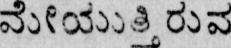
ಮೇಯುತ್ತಿರುವ
